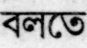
বলতে
